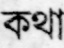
কথা
